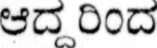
ಆದ್ದರಿಂದ
